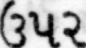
ઉપર
